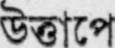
উত্তাপে
